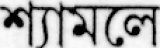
শ্যামলে
